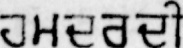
ਹਮਦਰਦੀ
